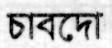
চবদো
